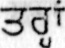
ਤਰ੍ਹਾਂ
